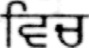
ਵਿਚ
